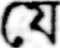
যে
